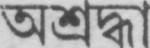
অশ্রদ্ধা
